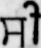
ਸੀ
